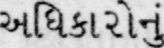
અધિકારોનું
